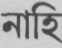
নাহি
